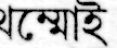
থম্মোই
